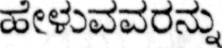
ಹೇಳುವವರನ್ನು
